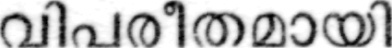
വിപരീതമായി
